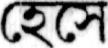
হেসে
